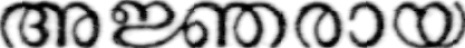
അജ്ഞരായ
